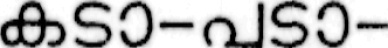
കടാ-പടാ-
